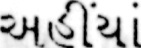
અહીંયો
